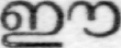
ഈ
